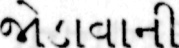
જોડાવાની
